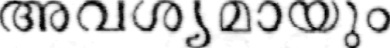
അവശ്യമായും
